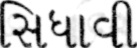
સિધાવી
